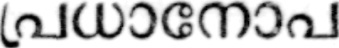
പ്രധാനോപ
